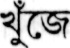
খুঁজে
